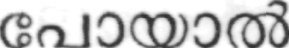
പോയാല്‍
